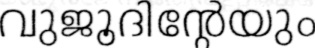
വുജുദിന്റേയും
